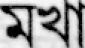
মখা
